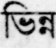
ভিন্ন
